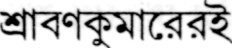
শ্রাবণকুমারেরই
